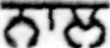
ਨਾਲ
